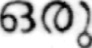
ഒരു
